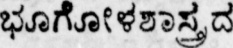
ಭೂಗೋಳಶಾಸ್ತ್ರದ
